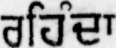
ਰਹਿੰਦਾ
